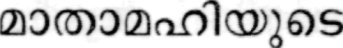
മാതാമഹിയുടെ
